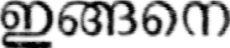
ഇങ്ങനെ
